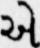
એ
